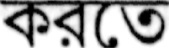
করতে
